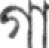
গা
